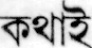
কথাই
